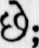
છે
